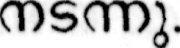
നടന്നു.
